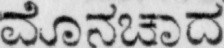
ಮೊನಚಾದ
